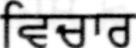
ਵਿਚਾਰ
